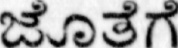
ಜೊತೆಗೆ
